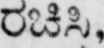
ರಚಿಸಿ,
